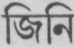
জিনি
